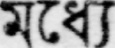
মধ্যে
